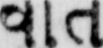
વાત
